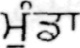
ਮੁੰਡਾ
